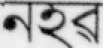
নহৱ
